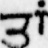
ਤਾਂ
